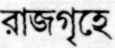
রাজগৃহে
